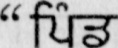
''ਪਿੰਡ
